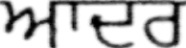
ਆਦਰ
